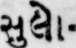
સુલો-
